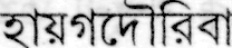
হায়গদৌরিবা
